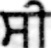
ਸੀ
